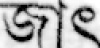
জাৎ
